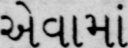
એવામાં
